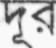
দূর
